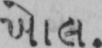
ખોલ.
